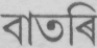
বাতৰি
